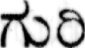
ಗುರಿ
